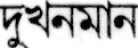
দুখনমান
